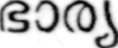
ഭാര്യ
